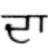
ਦਾ
